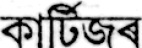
কাৰ্টিজৰ
